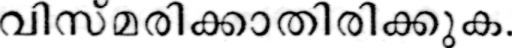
വിസ്മരിക്കാതിരിക്കുക.
